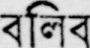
বলিব
